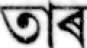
তাৰ
